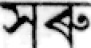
সৰু
